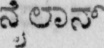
ನೈಲಾನ್
